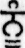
ਨੂੰ
